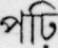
পঢ়ি
